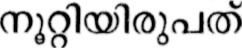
നൂറ്റിയിരുപത്
